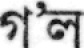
গ'ল
